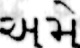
'અમે
